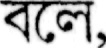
বলে,
